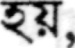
হয়,
